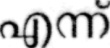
എന്ന്
